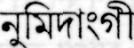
নুমিদাংগী
